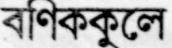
বণিককুলে
